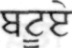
ਬਟੂਏ
